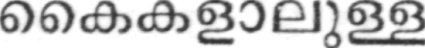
കൈകളാലുള്ള
